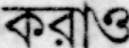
করাও
